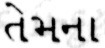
તેમના
